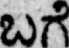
ಬಗೆ
